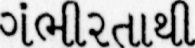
ગંભીરતાથી
